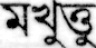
মখুত্তু
